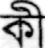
কী
